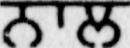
ਨਾਲ
